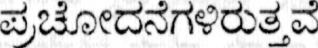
ಪ್ರಚೋದನೆಗಳಿರುತ್ತವೆ
